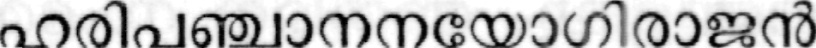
ഹരിപഞ്ചാനനയോഗിരാജന്‍
